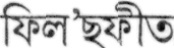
ফিল'ছফীত
